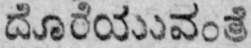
ದೊರೆಯುವಂತೆ
